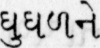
ઘુઘળને
